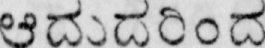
ಆದುದರಿಂದ
